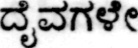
ದೈವಗಳೇ
